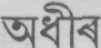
অধীৰ
